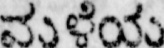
ಮಳೆಯ
